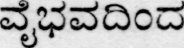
ವೈಭವದಿಂದ
